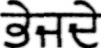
ਭੇਜਦੇ
